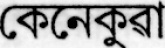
কেনেকুৱা
